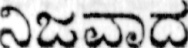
ನಿಜವಾದ
